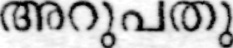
അറുപതു
